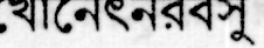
খোনেৎনরবসু
